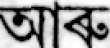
আৰু
